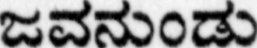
ಜವನುಂಡು
